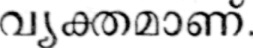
വ്യക്തമാണ്.
